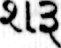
શરૂ
